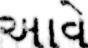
આવે
